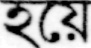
হয়ে
